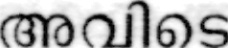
അവിടെ
